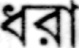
ধরা
